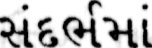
સંદર્ભમાં
